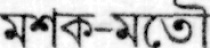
মশক-মতৌ
